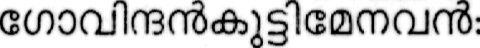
ഗോവിന്ദന്‍കുട്ടിമേനവന്‍:
